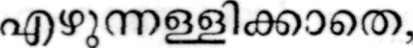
എഴുന്നള്ളിക്കാതെ,
